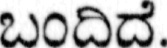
ಬಂದಿದೆ.
